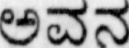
ಅವನ
